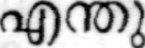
എന്തു
